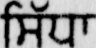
ਸਿੱਧਾ
